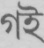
গই
